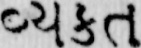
વ્યકત
